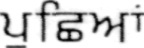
ਪੁਛਿਆਂ
